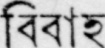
বিবাহ
